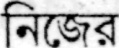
নিজের
